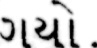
ગયો.
